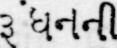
રૂંધનની
